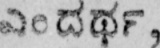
ಎಂದರ್ಥ,
